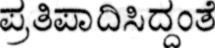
ಪ್ರತಿಪಾದಿಸಿದ್ದಂತೆ
